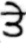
ਤੇ
